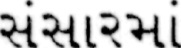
સંસારમાં
